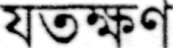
যতক্ষণ
